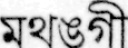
মথঙগী
